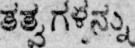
ತತ್ವಗಳನ್ನು
